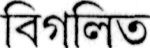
বিগলিত
